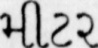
મીટર
